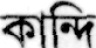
কান্দি
